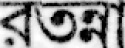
রতন্না
